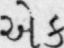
એક
